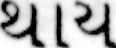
થાય
